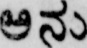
ಅನು
